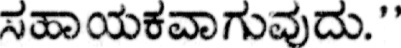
ಸಹಾಯಕವಾಗುವುದು."
